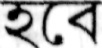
হবে
